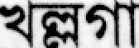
খল্লগা
